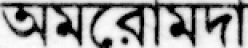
অমরোমদা
